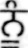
ਨੂੰ
